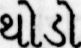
થોડો
